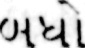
બધો
